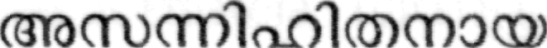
അസന്നിഹിതനായ
